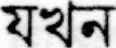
যখন
